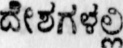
ದೇಶಗಳಲ್ಲಿ
